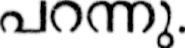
പറന്നു.
